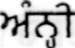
ਅੰਨ੍ਹੀ
